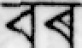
বৰ
